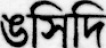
ঙসিদি
